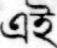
এই
